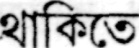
থাকিতে
